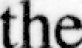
the
